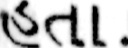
હતા.
